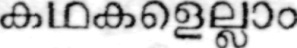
കഥകളെല്ലാം
